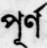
পূর্ণ
